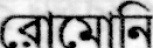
রোমোনি
